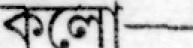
কলো-
